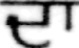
ਦਾ
